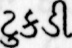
ટુકડી
